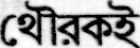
থৌরকই
